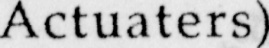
Actuaters)
